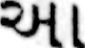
આ
